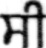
ਸੀ
